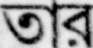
তার
